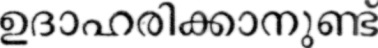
ഉദാഹരിക്കാനുണ്ട്
